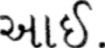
આઈ.
